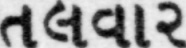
તલવાર
